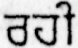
ਰਹੀ
